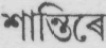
শান্তিৰে
